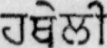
ਹਥੇਲੀ
